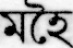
মহৈ
